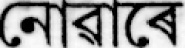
নোৱাৰে
